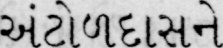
અંટોળદાસને
